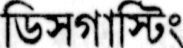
ডিসগাস্টিং
